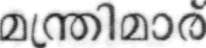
മന്ത്രിമാര്
